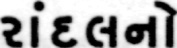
રાંદલનો
